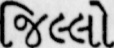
જિલ્લો
